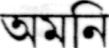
অমনি
